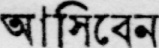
আসিবেন
